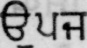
ਉਪਜ
